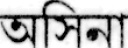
অসিনা
